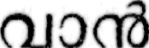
വാന്‍
